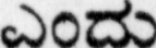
ಎಂದು
